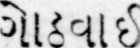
ગોઠવાઈ
